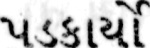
પડકાર્યો
